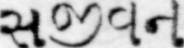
સજીવન
